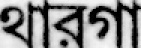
থারগা
